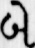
બે
